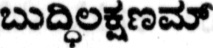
ಬುದ್ಧಿಲಕ್ಷಣಮ್
